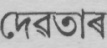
দেৱতাৰ
